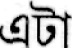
এটা
